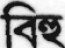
বিহু
